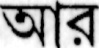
আর
